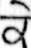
ਕੇ
